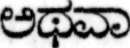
ಅಥವಾ
